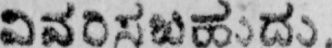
ವಿವರಿಸಬಹುದು.
